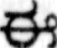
ಈ
